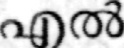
എല്‍
